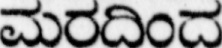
ಮರದಿಂದ
